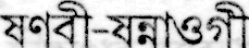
ষণবী-ষন্নাওগী
